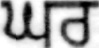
ਘਰ
